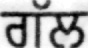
ਗੱਲ
